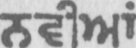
ਨਵੀਆਂ
